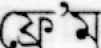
ফ্ৰে'ম
